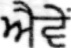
ਐਵੇਂ
